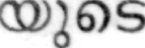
യുടെ
